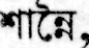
শান্নৈ,
